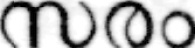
സരം
